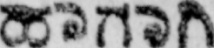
ಹಾಗಾಗಿ
